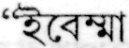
“ইবেম্মা
